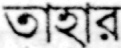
তাহার
